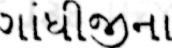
ગાંધીજીના
